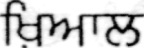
ਖ਼ਿਆਲ
